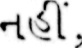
નહીં,
